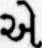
એ
